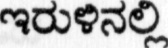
ಇರುಳಿನಲ್ಲಿ
